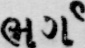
ભર્ગ
